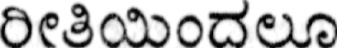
ರೀತಿಯಿಂದಲೂ
